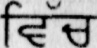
ਵਿੱਚ
